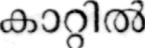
കാറ്റില്‍
